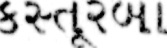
કસ્તૂરબા
